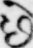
છે
